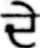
ਦੇ
